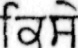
ਕਿਸੇ
